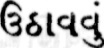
ઉઠાવવું
